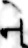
ને
